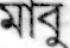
মাবু
